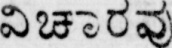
ವಿಚಾರವು
